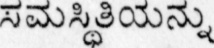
ಸಮಸ್ಥಿತಿಯನ್ನು
